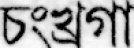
চংখ্রগা
